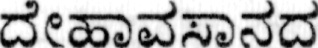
ದೇಹಾವಸಾನದ
